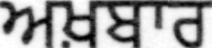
ਅਖ਼ਬਾਰ
